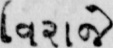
વિરાજે
